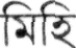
মিহি
